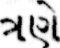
ત્રણે
